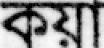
কয়া
